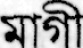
মাগী
